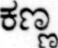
ಕಣ್ಣ
